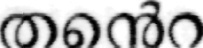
തന്റെ
